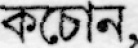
কচোন,
